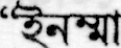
“ইনম্মা
